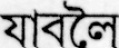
যাবলৈ
